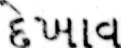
દેખાવ
